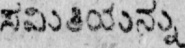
ಸಮಿತಿಯನ್ನು
